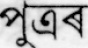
পুত্রৰ
